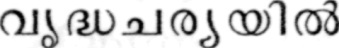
വൃദ്ധചര്യയില്‍
